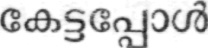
കേട്ടപ്പോള്‍
